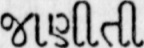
જાણીતા
